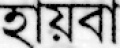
হায়বা
